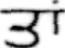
ਤਾਂ
